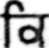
ਕਿ
